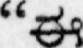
“ಈ
